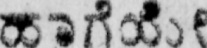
ಹಾಗೆಯೇ
